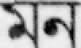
মন
